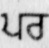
ਪਰ
